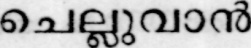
ചെല്ലുവാന്‍
